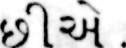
છીએ.
